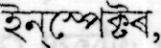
ইন্‌স্পেক্টৰ,
